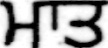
ਮਾਤ
